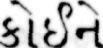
કોઈને
